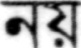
নয়
